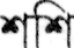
শশি
